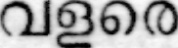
വളരെ
